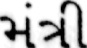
મંત્રી
